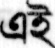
এই
